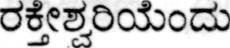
ರಕ್ತೇಶ್ವರಿಯೆಂದು
